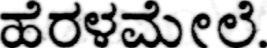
ಹೆರಳಮೇಲೆ.
